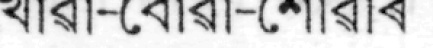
খোৱা-বোৱা-শোৱাৰ
